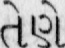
તેણે
